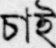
চাই
